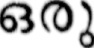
ഒരു
